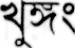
খুঙ্গং
